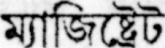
ম্যাজিষ্ট্রেট
